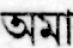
অমা
